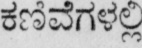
ಕಣಿವೆಗಳಲ್ಲಿ
